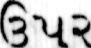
ઉપર
